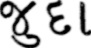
જુદા
